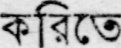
করিতে
